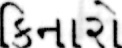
કિનારો
